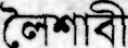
লৈশাবী
